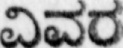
ವಿವರ
